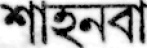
শাহনবা
